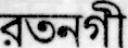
রতনগী
